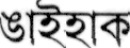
ঙাইহাক
